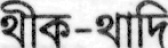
থীক-থাদি
